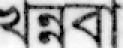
খন্নবা
